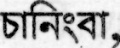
চানিংবা,
